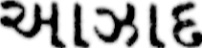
આઝાદ
